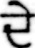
ਦੇ
